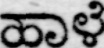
ಹಾಳೆ
